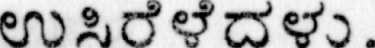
ಉಸಿರೆಳೆದಳು.
